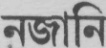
নজানি
